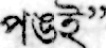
পঙই”
